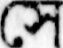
সে
